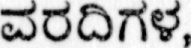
ವರದಿಗಳ,
